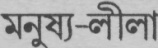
মনুষ্য-লীলা
